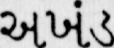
અખંડ
